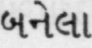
બનેલા
